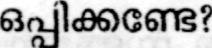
ഒപ്പിക്കണ്ടേ?
